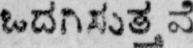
ಒದಗಿಸುತ್ತವೆ
